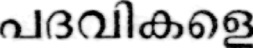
പദവികളെ
